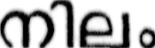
നിലം
